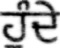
ਹੁੰਦੇ
